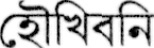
হৌখিবনি
